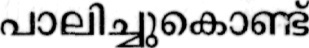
പാലിച്ചുകൊണ്ട്
